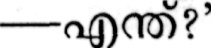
-എന്ത്?'
